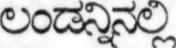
ಲಂಡನ್ನಿನಲ್ಲಿ
